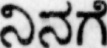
ನಿನಗೆ
